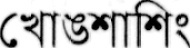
খোঙশাশিং
